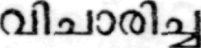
വിചാരിച്ച
